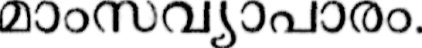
മാംസവ്യാപാരം
